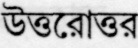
উত্তরোত্তর
